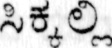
ಸಿಕ್ಕಲ್ಲಿ
